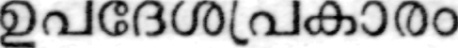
ഉപദേശപ്രകാരം
